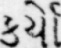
કર્યો
